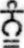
ਨੂੰ
